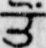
ਤੋਂ
